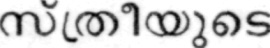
സ്ത്രീയുടെ
